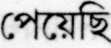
পেয়েছি
